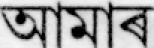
আমাৰ
